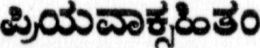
ಪ್ರಿಯವಾಕ್ಸಹಿತಂ
